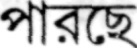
পারছে
